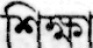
শিক্ষা
